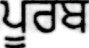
ਪੂਰਬ
